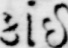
કાંઈ
